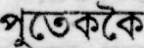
পুতেককৈ
